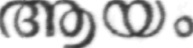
ആയം
